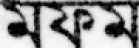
মফম
